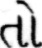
તો
